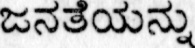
ಜನತೆಯನ್ನು
